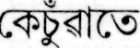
কেচুঁৱাতে
